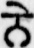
ਨੇ
